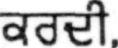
ਕਰਦੀ,
